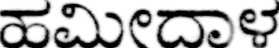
ಹಮೀದಾಳ
